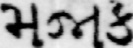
મજાક
